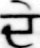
ਦੇ
